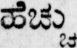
ಹೆಚ್ಚು
